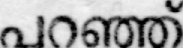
പറഞ്ഞ്
